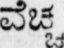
ವೆಚ್ಚ
